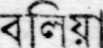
বলিয়া
